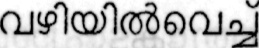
വഴിയില്‍വെച്ച്
